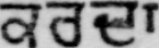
ਕਰਦਾ
